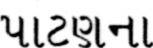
પાટણના
